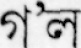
গ'ল
